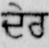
ਦੇਰ
